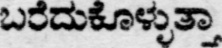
ಬರೆದುಕೊಳ್ಳುತ್ತಾ
